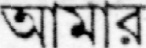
আমার
